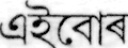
এইবোৰ
